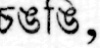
চঙঙি,
